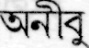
অনীবু
